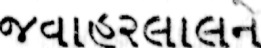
જવાહરલાલને
